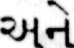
અને
